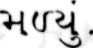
મળ્યું.
